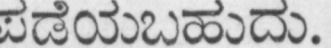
ಪಡೆಯಬಹುದು.
